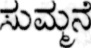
ಸುಮ್ಮನೆ
